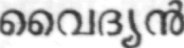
വൈദ്യന്‍
